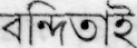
বন্দিতাই
